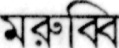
মরুব্বি
